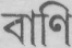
বাণি
